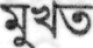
মুখত
